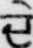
ਦੇ
